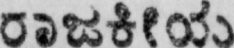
ರಾಜಕೀಯ
